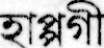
হাপ্পগী
